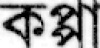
কপ্পা
